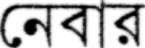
নেবার
